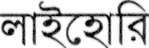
লাইহোরি
